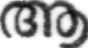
ആ
